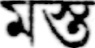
মস্ত
